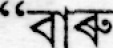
"বাৰু
